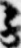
કે
